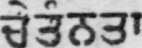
ਚੇਤੰਨਤਾ
